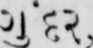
ગુંદર
